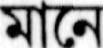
মানে
